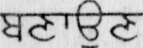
ਬਣਾਉਣ
